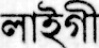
লাইগী
